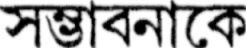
সম্ভাবনাকে
